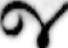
જ
